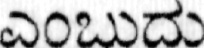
ಎಂಬುದು
